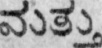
ಮತ್ತು
